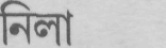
নিলা
